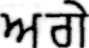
ਅਗੇ
